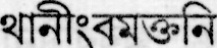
থানীংবমক্তনি
